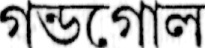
গন্ডগোল
